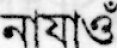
নাযাওঁ
